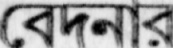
বেদনার
